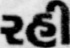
રહી
